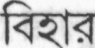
বিহার
